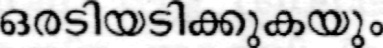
ഒരടിയടിക്കുകയും
